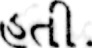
હતી.
